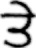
ਤੇ
